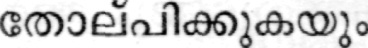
തോല്പിക്കുകയും
